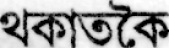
থকাতকৈ
